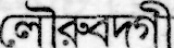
লৌরুবদগী
